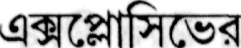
এক্সপ্লোসিভের
